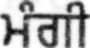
ਮੰਗੀ
